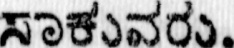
ಸಾಕುವರು.
